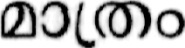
മാത്രം
